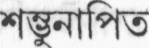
শম্ভুনাপিত
